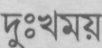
দুঃখময়
